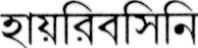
হায়রিবসিনি
